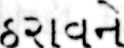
ઠરાવને
